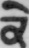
ਕੇ
